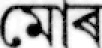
মোৰ
